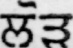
ਲੋੜ
